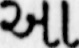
આ
